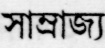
সাম্রাজ্য
